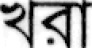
খরা
